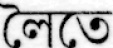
লৈতে
